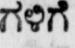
ಗಳಿಗೆ
